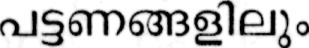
പട്ടണങ്ങളിലും
